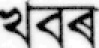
খবৰ
